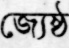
জ্যেষ্ঠ
